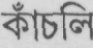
কাঁচলি
